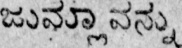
ಜುಮ್ಲಾವನ್ನು
